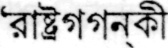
‘রাষ্ট্রগগন্‌কী
